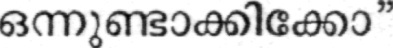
ഒന്നുണ്ടാക്കിക്കോ”
